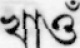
খাওঁ
